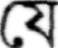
যে
